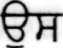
ਉਸ
